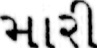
મારી
